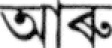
আৰু
